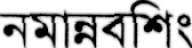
নমান্নবশিং
